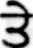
ਤੇ
